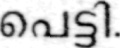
പെട്ടി.
